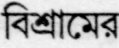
বিশ্রামের
